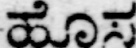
ಹೊಸ
